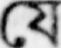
যে
